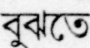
বুঝতে
